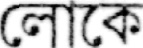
লোকে
